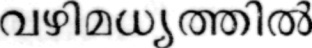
വഴിമധ്യത്തില്‍
